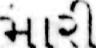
મારી
